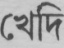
খেদি
